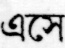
এসে
